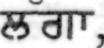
ਲੱਗਾ,
